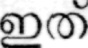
ഇത്
